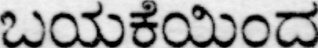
ಬಯಕೆಯಿಂದ
